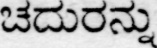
ಚದುರನ್ನು
